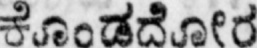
ಕೊಂಡದೋರ
